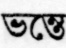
ভন্তে
